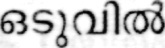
ഒടുവില്‍
